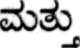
ಮತ್ತು
